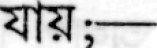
যায়;-
